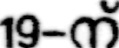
19-ന്
